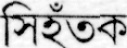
সিহঁতক
